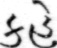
કહે
